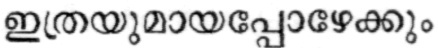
ഇത്രയുമായപ്പോഴേക്കും
